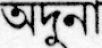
অদুনা
